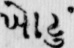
ખોટું
